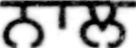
ਨਾਲ
